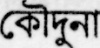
কৌদুনা
